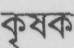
কৃষক
